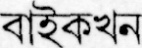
বাইকখন
